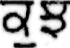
ਕੁਝ
